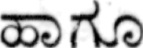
ಹಾಗೂ
